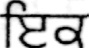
ਇਕ
